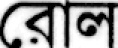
রোল
